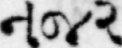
નજર
